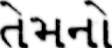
તેમનો
